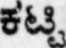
ಕಟ್ಟಿ
